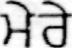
ਮੇਰੇ
